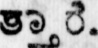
ತ್ತಾರೆ.
